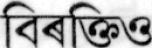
বিৰক্তিও
